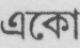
একো
